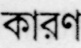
কারণ
